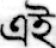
এই
